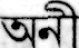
অনী
